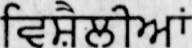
ਵਿਸ਼ੈਲੀਆਂ
